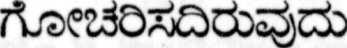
ಗೋಚರಿಸದಿರುವುದು
